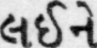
લઈને
